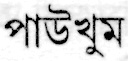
পাউখুম
